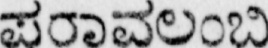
ಪರಾವಲಂಬಿ
